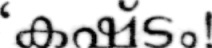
'കഷ്ടം!
